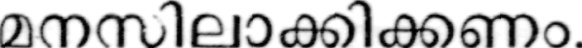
മനസിലാക്കിക്കണം.
